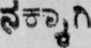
ನಕ್ಕಾಗಿ
